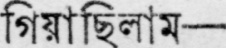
গিয়াছিলাম—
